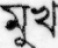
মুখ
